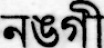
নঙগী
